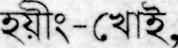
হয়ীং-খোই,
